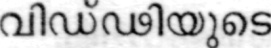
വിഡ്ഢിയുടെ
